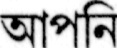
আপনি
